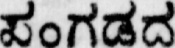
ಪಂಗಡದ
